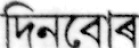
দিনবোৰ
